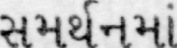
સમર્થનમાં
